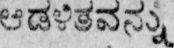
ಆಡಳಿತವನ್ನು
